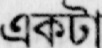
একটা
